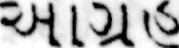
આગ્રહ
